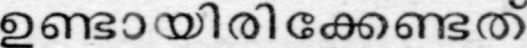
ഉണ്ടായിരിക്കേണ്ടത്
